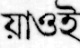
য়াওই
